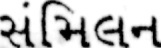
સંમિલન
